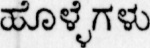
ಹೊಳ್ಳೆಗಳು
